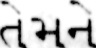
તેમને
